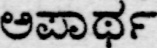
ಅಪಾರ್ಥ
